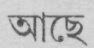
আছে
